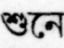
শুনে
